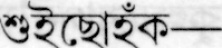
শুইছোহঁক-
